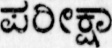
ಪರೀಕ್ಷಾ
